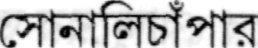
সোনালিচাঁপার
